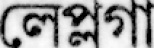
লেপ্লগা
